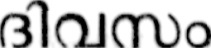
ദിവസം
